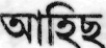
আহিছ
